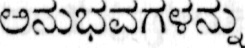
ಅನುಭವಗಳನ್ನು
